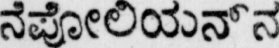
ನೆಪೋಲಿಯನ್‌ನ
